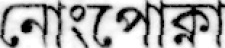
নোংপোক্না
